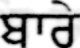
ਬਾਰੇ
